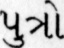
પુત્રો
